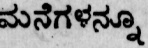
ಮನೆಗಳನ್ನೂ
